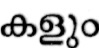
കളും
